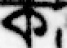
কা
